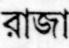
রাজা
